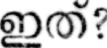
ഇത്?
